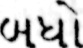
બધો
